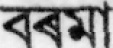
বৰমা
